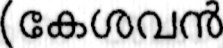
(കേശവന്‍
